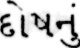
દોષનું
